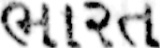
ભારત
